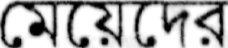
মেয়েদের
